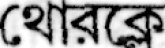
থোরক্লে
